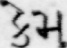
કેમ
